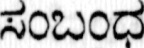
ಸಂಬಂಧ
